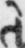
તે
